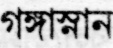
গঙ্গাস্নান
